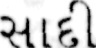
સાદી
